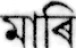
মাৰি
